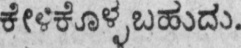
ಕೇಳಿಕೊಳ್ಳಬಹುದು.
